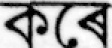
কৰে
